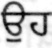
ਉਹ
